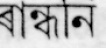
ৰান্ধনি
